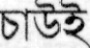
চাউই
